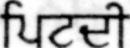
ਪਿਟਦੀ
